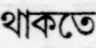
থাকতে
